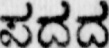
ಪದದ
